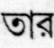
তার
